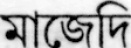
মাজেদি
